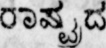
ರಾಷ್ಟ್ರದ
